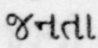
જનતા
